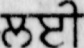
ਲਈ
